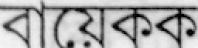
বায়েকক
